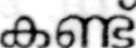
കണ്ട്
